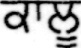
ਕਾਲੂ
